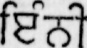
ਇੰਨੀ
